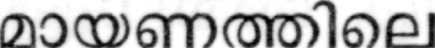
മായണത്തിലെ
